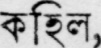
কহিল,
